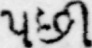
પછી
